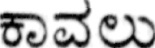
ಕಾವಲು
